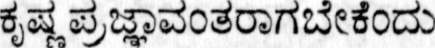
ಕೃಷ್ಣಪ್ರಜ್ಞಾವಂತರಾಗಬೇಕೆಂದು
